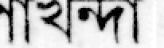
পাখন্দা
